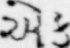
એક
